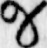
જ
